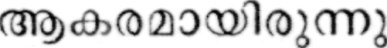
ആകരമായിരുന്നു
